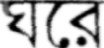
ঘরে
